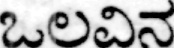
ಒಲವಿನ
